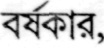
বর্ষকার,
